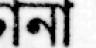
চানা
